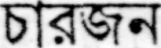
চারজন
